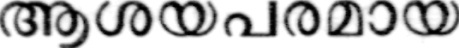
ആശയപരമായ
